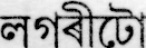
লগৰীটো
